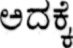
ಅದಕ್ಕೆ
